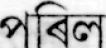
পৰিল
